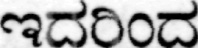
ಇದರಿಂದ
